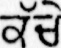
ਕੱਚੇ
